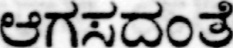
ಆಗಸದಂತೆ
